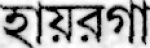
হায়রগা
